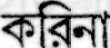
করিনা
